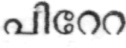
പിറേറ
